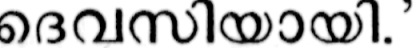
ദെവസിയായി.’
